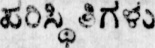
ಪರಿಸ್ಥಿತಿಗಳು
